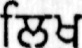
ਲਿਖ
